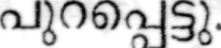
പുറപ്പെട്ടു.
